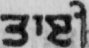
ਤਾਈ
